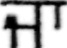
ਜਾ
